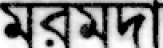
মরমদা
